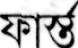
ফার্স্ত
